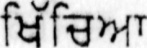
ਖਿੱਚਿਆ
